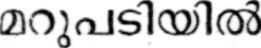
മറുപടിയില്‍
